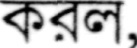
করল,
